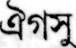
ঐগসু
